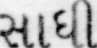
સાધી
